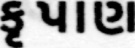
કૃપાણ
